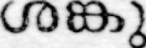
ശങ്കു
